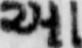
આ
